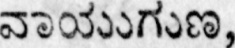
ವಾಯುಗುಣ,
